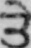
ਤੇ
